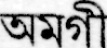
অমগী
